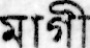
মাগী
